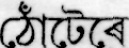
ঠোঁটেৰে
